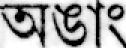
অঙাং
